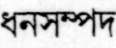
ধনসম্পদ
